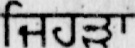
ਜਿਹੜਾ
